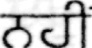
ਨਹੀਂ
